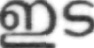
ഇട
